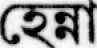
হেন্না
